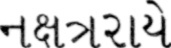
નક્ષત્રરાયે
